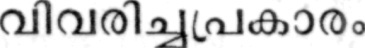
വിവരിച്ചപ്രകാരം
